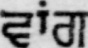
ਵਾਂਗ
